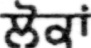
ਲੋਕਾਂ
